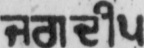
ਜਗਦੀਪ
